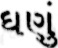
ઘણું
